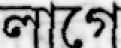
লাগে
